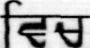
ਵਿਚ
